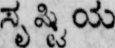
ಸೃಷ್ಟಿಯ
